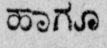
ಹಾಗೂ
